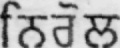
ਨਿਰੋਲ
